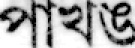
পাখঙ
